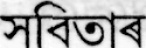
সবিতাৰ
